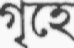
গৃহে
